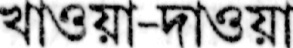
খাওয়া-দাওয়া
